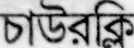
চাউরক্লি
